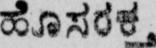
ಹೊಸರಕ್ತ
